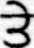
ਤੇ
